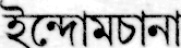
ইন্দোমচানা
